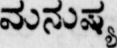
ಮನುಷ್ಯ
